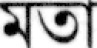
মতা
